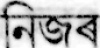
নিজৰ
